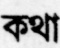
কথা
